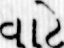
વાટે
